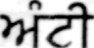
ਅੰਟੀ
